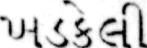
ખડકેલી
